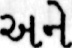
અને
